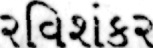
રવિશંકર
